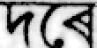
দৰে
